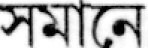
সমানে
